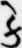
કે
